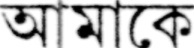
আমাকে
